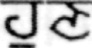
ਹੁਣ
